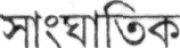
সাংঘাতিক
